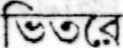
ভিতরে
